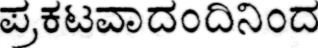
ಪ್ರಕಟವಾದಂದಿನಿಂದ
